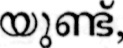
യുണ്ട്,
